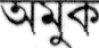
অমুক
